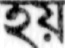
হয়
